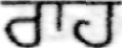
ਰਾਹ
